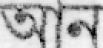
আন
